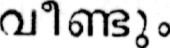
വീണ്ടും
